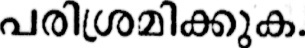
പരിശ്രമിക്കുക.
